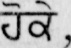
ਹੋਕੇ,
